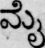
ಮೈ
